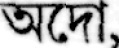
অদো,
